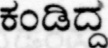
ಕಂಡಿದ್ದ
